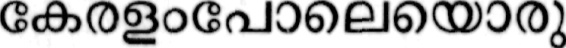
കേരളംപോലെയൊരു
